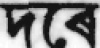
দৰে
